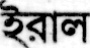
ইরাল
